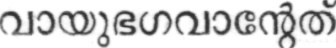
വായുഭഗവാന്റേത്
